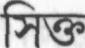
সিক্ত
